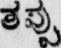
ತಪ್ಪು
